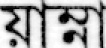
য়াম্না
